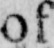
of
